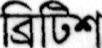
ব্রিটিশ
